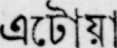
এটোয়া
